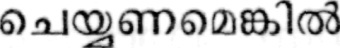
ചെയ്യണമെങ്കില്‍
